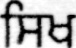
ਸਿਖ
